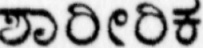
ಶಾರೀರಿಕ
